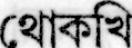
থোকখি
